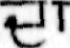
ਦਾ
